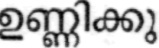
ഉണ്ണിക്കു
